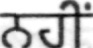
ਨਹੀਂ
